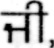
ਜੀ,
